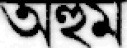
অহুম
